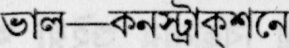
ভাল-কনস্ট্রাক্‌শনে
